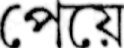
পেয়ে
